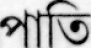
পাতি
